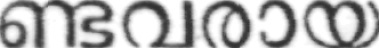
ണ്ടവരായ
